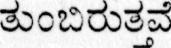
ತುಂಬಿರುತ್ತವೆ
